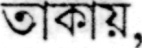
তাকায়,
